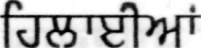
ਹਿਲਾਈਆਂ
